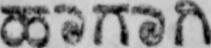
ಹಾಗಾಗಿ
